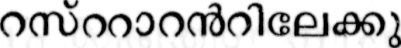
റസ്ററാറന്റിലേക്കു
